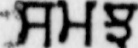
ਸਮਝ
